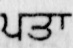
ਪਤਾ
